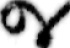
જ
